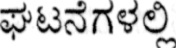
ಘಟನೆಗಳಲ್ಲಿ
